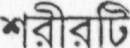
শরীরটি
